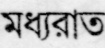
মধ্যরাত
